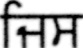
ਜਿਸ
